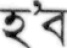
হ'ব
